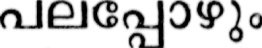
പലപ്പോഴും
